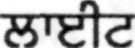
ਲਾਈਟ
